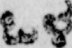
ಒಳ
